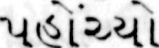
પહોંચ્યો
